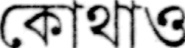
কোথাও
